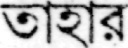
তাহার
